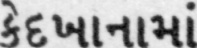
કેદખાનામાં
